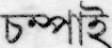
চম্পাই
